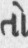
તો
